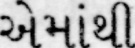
એમાંથી
